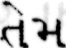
તેમ
